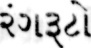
રંગરૂટો
